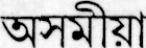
অসমীয়া
